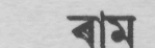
ৰাম
